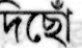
দিছোঁ
